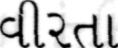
વીરતા
